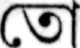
তো
